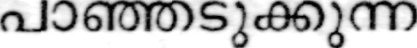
പാഞ്ഞടുക്കുന്ന
